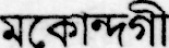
মকোন্দগী
